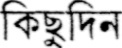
কিছুদিন
